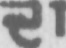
ਦਾ
